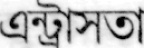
অন্ট্রাসতা
